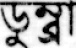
ডুম্ব্রা
